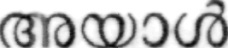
അയാള്‍
